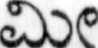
ಮೀ
